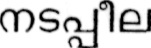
നടപ്പീല
